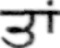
ਤਾਂ
